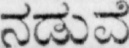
ನಡುವೆ
